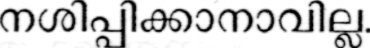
നശിപ്പിക്കാനാവില്ല.
